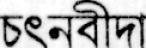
চৎনবীদা
